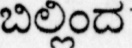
ಬಿಲ್ಲಿಂದ
